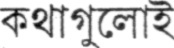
কথাগুলোই
